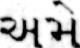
અમે
